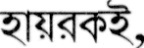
হায়রকই,
